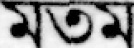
মতম
